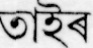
তাইৰ
